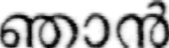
ഞാന്‍
